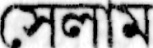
সেলাম
